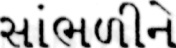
સાંભળીને
